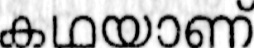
കഥയാണ്
